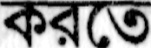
করতে
